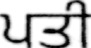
ਪਤੀ
